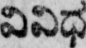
ವಿವಿಧ
